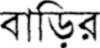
বাড়ির
